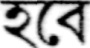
হবে
